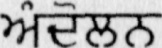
ਅੰਦੋਲਨ
